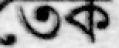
তেক
